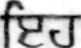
ਇਹ
